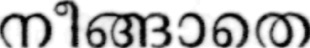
നീങ്ങാതെ
